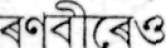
ৰণবীৰেও
